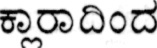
ಕ್ಲಾರಾದಿಂದ
